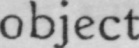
object
